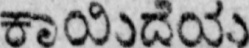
ಕಾಯಿದೆಯ
